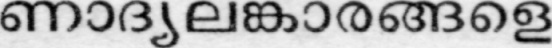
ണാദ്യലങ്കാരങ്ങളെ
